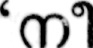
'നീ
